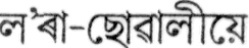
ল'ৰা-ছোৱালীয়ে
